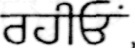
ਰਹੀਓਂ,
